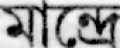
মান্দ্রে
